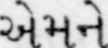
એમને
